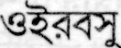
ওইরবসু
